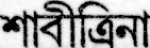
শাবীত্রিনা
